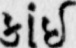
કાંઈ
